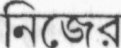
নিজের
